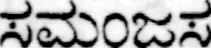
ಸಮಂಜಸ
